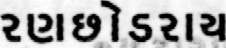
રણછોડરાય
